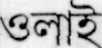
ওলাই
